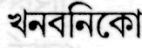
খনবনিকো
